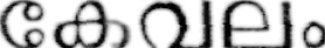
കേവലം
